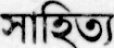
সাহিত্য
